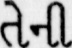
તેની
